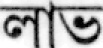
লাভ
